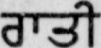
ਰਾਤੀ
